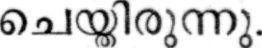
ചെയ്തിരുന്നു.
